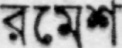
রমেশ
